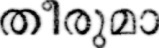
തീരുമാ
